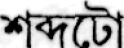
শব্দটো
